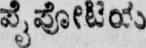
ಪೈಪೋಟಿಯ
